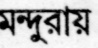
মন্দুরায়
